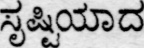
ಸೃಷ್ಟಿಯಾದ
